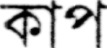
কাপ
